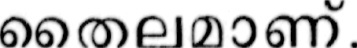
തൈലമാണ്.
